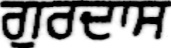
ਗੁਰਦਾਸ
